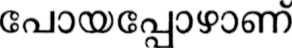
പോയപ്പോഴാണ്
